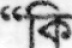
"কি
